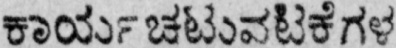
ಕಾರ್ಯಚಟುವಟಿಕೆಗಳ
